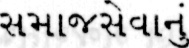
સમાજસેવાનું
